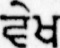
ਵੇਖ
